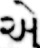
એ
